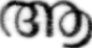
ആ
